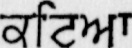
ਕਟਿਆ
